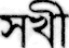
সখী
